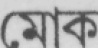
মোক
